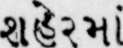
શહેરમાં
